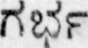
ಗರ್ಭ
